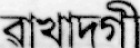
ৱাখাদগী
